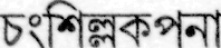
চংশিল্লকপনা
